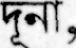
দূনা,
